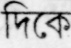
দিকে
